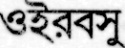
ওইরবসু
